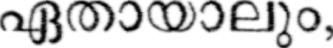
ഏതായാലും,
